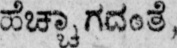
ಹೆಚ್ಚಾಗದಂತೆ,
